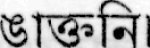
ঙাক্তনি।
